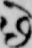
છે
